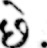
છે.
